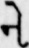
ને
